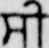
ਸੀ
